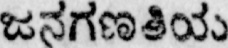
ಜನಗಣತಿಯ
